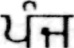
ਪੰਜ
